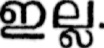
ഇല്ല.
